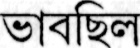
ভাবছিল
